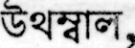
উথম্বাল,
